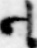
ન
